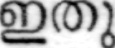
ഇതു
